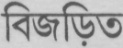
বিজড়িত
